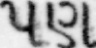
પણ
